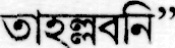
তাহল্লবনি”
